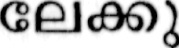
ലേക്കു
